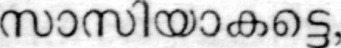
സാസിയാകട്ടെ,
